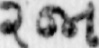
રજા
